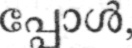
പ്പോള്‍,
